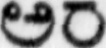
ಅರ
